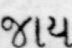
જાય
